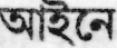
আইনে
